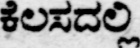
ಕೆಲಸದಲ್ಲಿ
